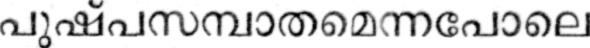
പുഷ്പസമ്പാതമെന്നപോലെ
